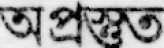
অপ্রস্তুত
